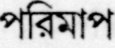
পরিমাপ
